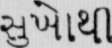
સુખોથી
